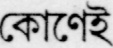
কোণেই
